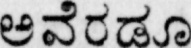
ಅವೆರಡೂ
